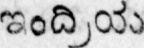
ಇಂದ್ರಿಯ
